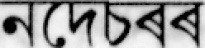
নদেচৰৰ
